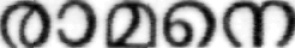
രാമനെ
